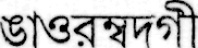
ঙাওরম্বদগী
